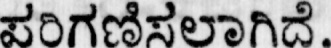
ಪರಿಗಣಿಸಲಾಗಿದೆ.
